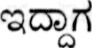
ಇದ್ದಾಗ
